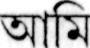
আমি
